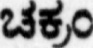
ಚಕ್ರಂ
